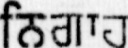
ਨਿਗਾਹ
